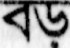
বড়
